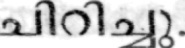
ചിറിച്ചു.
